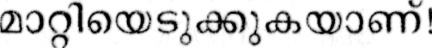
മാറ്റിയെടുക്കുകയാണ്!
